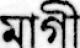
মাগী
